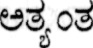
ಅತ್ಯಂತ
